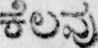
ಕೆಲವು
